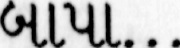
બાપા...
